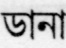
ডানা
